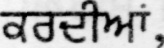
ਕਰਦੀਆਂ,
